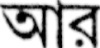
আর
